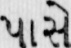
પાસે
